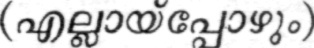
(എല്ലായ്പ്പോഴും)
